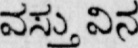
ವಸ್ತುವಿನ
